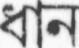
ধান
